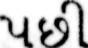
પછી
